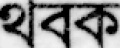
থবক
